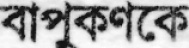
বাপুকণকে
